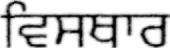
ਵਿਸਥਾਰ
